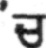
'ਚ
